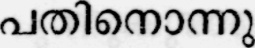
പതിനൊന്നു
